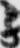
કે
